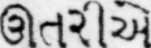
ઊતરીએ
